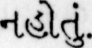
નહોતું.
